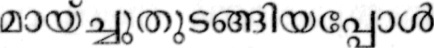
മായ്ച്ചുതുടങ്ങിയപ്പോള്‍
